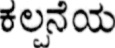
ಕಲ್ಪನೆಯ
